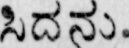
ಸಿದನು.
